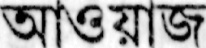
আওয়াজ
